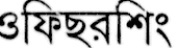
ওফিছারশিং
